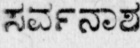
ಸರ್ವನಾಶ
